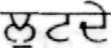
ਲੁਟਦੇ
